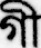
গী
